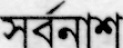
সর্বনাশ
